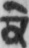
ਕੇ
